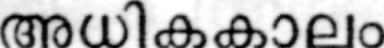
അധികകാലം
